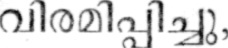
വിരമിപ്പിച്ചു,
